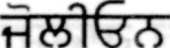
ਜੋਲੀਓਨ
